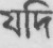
যদি
